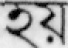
হয়
